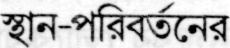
স্থান-পরিবর্তনের
